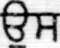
ਉਸ
